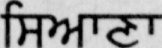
ਸਿਆਣਾ
